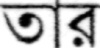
তার
